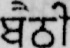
ਬੈਠੀ
